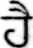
ਹੈ
